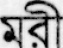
মরী
